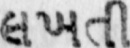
લખતી
